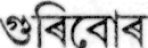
গুৰিবোৰ
